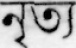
নৃত্য
